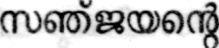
സഞ്ജയന്റെ
